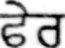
ਫੇਰ
